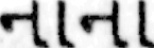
નાના
